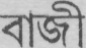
বাজী
